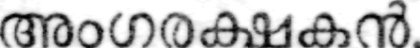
അംഗരക്ഷകന്‍.
